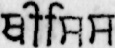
ਥੀਸਿਸ
